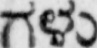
ಗಳು
